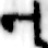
ન
